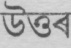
উত্তৰ
